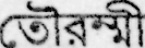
তৌরম্মী
